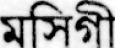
মসিগী
